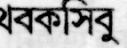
থবকসিবু
